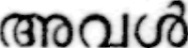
അവള്‍
